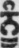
ਨੂੰ
